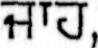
ਜਾਹ,
